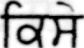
ਕਿਸੇ
